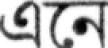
এনে
